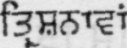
ਤ੍ਰਿਸ਼ਨਾਵਾਂ
